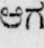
ಆಗ
